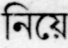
নিয়ে
